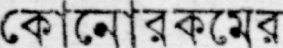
কোনোরকমের
